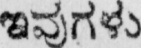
ಇವುಗಳು
